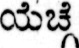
ಯೆಚ್ಗೆ
